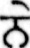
ਨੇ
